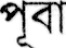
পূবা
